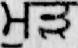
ਮੁੜ
